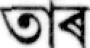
তাৰ
